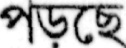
পড়ছে
